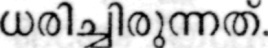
ധരിച്ചിരുന്നത്.
